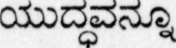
ಯುದ್ಧವನ್ನೂ
